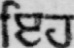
ਇਹ
